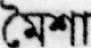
মৈশা
